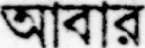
আবার
